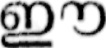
ഈ
